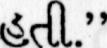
હતી."
